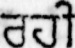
ਰਹੀ
